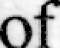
of
